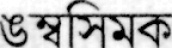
ঙম্বসিমক
